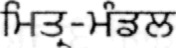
ਮਿਤ੍ਰ-ਮੰਡਲ
